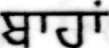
ਬਾਹਾਂ
